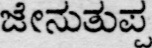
ಜೇನುತುಪ್ಪ
